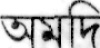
অমদি
